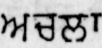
ਅਚਲਾ
